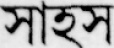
সাহস
